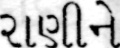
રાણીને
